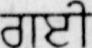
ਗਈ
